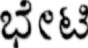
ಭೇಟಿ
